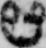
ಆ
